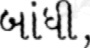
બાંધી,
